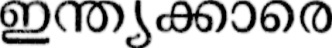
ഇന്ത്യക്കാരെ
